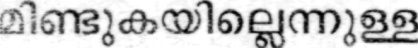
മിണ്ടുകയില്ലെന്നുള്ള
